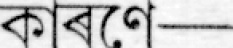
কাৰণে-
